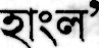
হাংল’
